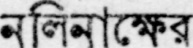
নলিনাক্ষের
